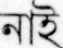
নাই
